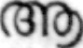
ആ
